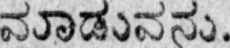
ಮಾಡುವನು.
